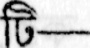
টি–
